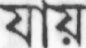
যায়
